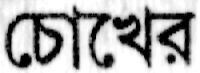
চোখের
